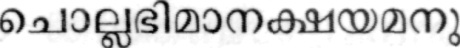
ചൊല്ലഭിമാനക്ഷയമനു
